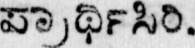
ಪ್ರಾರ್ಥಿಸಿರಿ.
